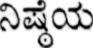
ನಿಷ್ಠೆಯ
